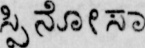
ಸ್ಪಿನೋಸಾ
